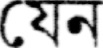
যেন
